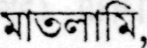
মাতলামি,
